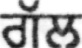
ਗੱਲ
